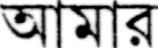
আমার
